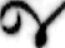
જ
